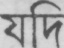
যদি
